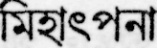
মিহাৎপনা
